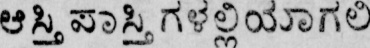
ಆಸ್ತಿಪಾಸ್ತಿಗಳಲ್ಲಿಯಾಗಲಿ
